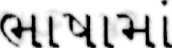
ભાષામાં
